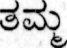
ತಮ್ಮ
